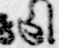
કહી
